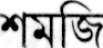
শমজি
